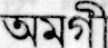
অমগী
